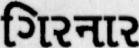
ગિરનાર
